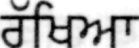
ਰੱਖਿਆ
